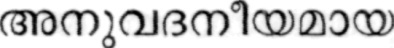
അനുവദനീയമായ
